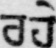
ਰਹੇ
